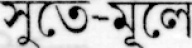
সুতে-মূলে
